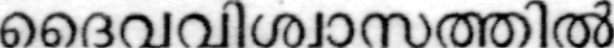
ദൈവവിശ്വാസത്തില്‍
